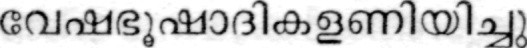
വേഷഭൂഷാദികളണിയിച്ചു
